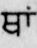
ਥਾਂ
